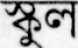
স্কুল
